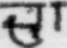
ਦਾ
